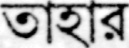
তাহার
